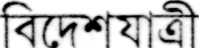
বিদেশযাত্রী
